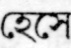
হেসে
